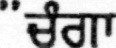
''ਚੰਗਾ
